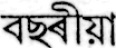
বছৰীয়া
